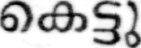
കെട്ടു
